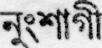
নুংশাগী
